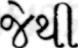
જેથી
